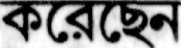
করেছেন
